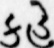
કહે
